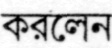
করলেন
